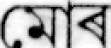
মোৰ
